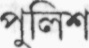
পুলিশ
